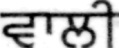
ਵਾਲੀ
